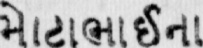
મોટાભાઈના
